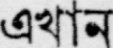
এখান
